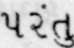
પરંતુ
